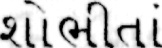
શોભીતાં
